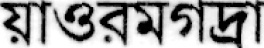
য়াওরমগদ্রা
